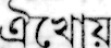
ঐখোয়
